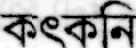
কৎকনি
